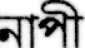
নাপী
